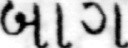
બાગ
